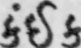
કંઈક
